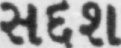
સદ્દશ
